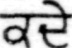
ਕਦੇ
